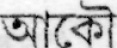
আকৌ
